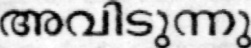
അവിടുന്നു
